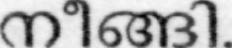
നീങ്ങി.
